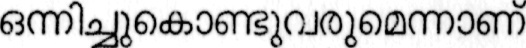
ഒന്നിച്ചുകൊണ്ടുവരുമെന്നാണ്
